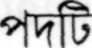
পদটি
